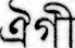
ঐগী
